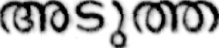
അടുത്ത
